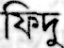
ফিদু
